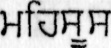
ਮਹਿਸੂਸ
